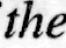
the
